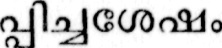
പ്പിച്ചശേഷം
